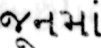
જૂનમાં
